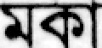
মকা
